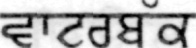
ਵਾਟਰਬੱਕ
